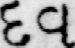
દવ
